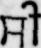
ਸੀ
